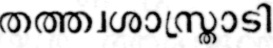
തത്ത്വശാസ്ത്രാടി
